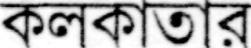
কলকাতার
